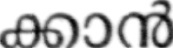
ക്കാന്‍
